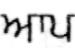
ਆਪ
